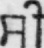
ਸੀ
